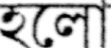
হলো
